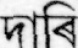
দাৰি
